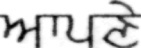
ਆਪਣੇ
